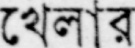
খেলার
